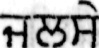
ਜਲਸੇ
